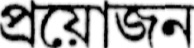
প্রয়োজন
